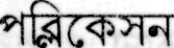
পব্লিকেসন
